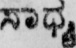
ಸಾಧ್ಯ
